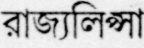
রাজ্যলিপ্সা
